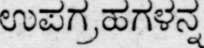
ಉಪಗ್ರಹಗಳನ್ನ
